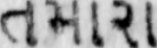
તમારા
